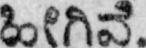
ಹೀಗಿವೆ.
